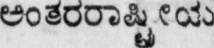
ಅಂತರರಾಷ್ಟ್ರೀಯ
